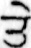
ਤੇ
